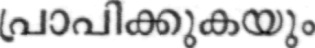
പ്രാപിക്കുകയും
